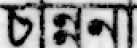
চান্ননা
